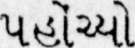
પહોંચ્યો
